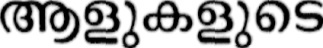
ആളുകളുടെ
